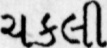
ચકલી
